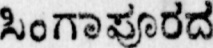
ಸಿಂಗಾಪೂರದ
